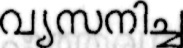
വ്യസനിച്ച
